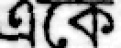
একে
